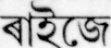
ৰাইজে
